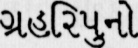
ગ્રહરિપુનો
